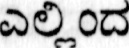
ಎಲ್ಲಿಂದ
